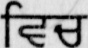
ਵਿਚ
